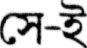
সে-ই
